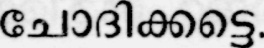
ചോദിക്കട്ടെ.
